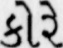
કોરે
